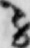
કે
